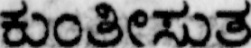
ಕುಂತೀಸುತ
